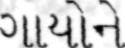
ગાયોને
